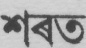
শৰত
